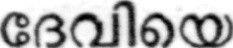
ദേവിയെ
